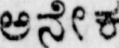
ಅನೇಕ
